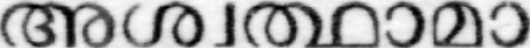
അശ്വത്ഥാമാ
